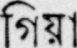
গিয়া
